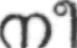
നീ
